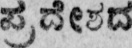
ಪ್ರದೇಶದ
